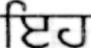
ਇਹ
